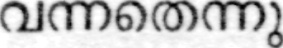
വന്നതെന്നു
